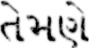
તેમણે
